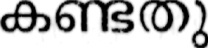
കണ്ടതു
